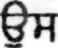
ਉਸ
